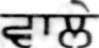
ਵਾਲੇ
